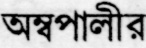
অম্বপালীর
